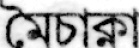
মৈচাক্না
